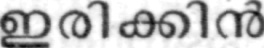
ഇരിക്കിന്‍
